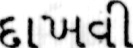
દાખવી
